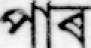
পাৰ
